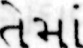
તેમાં
